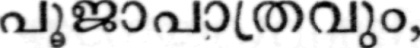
പൂജാപാത്രവും,
